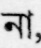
না,
